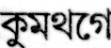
কুমথগে
